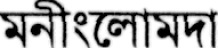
মনীংলোমদা
